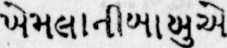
'ખેમલાનીબાબુએ
